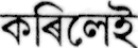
কৰিলেই
